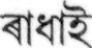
ৰাধাই
